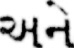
અને
